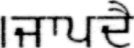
ਜਾਪਦੈ
